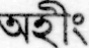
অহীং
